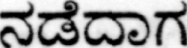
ನಡೆದಾಗ
